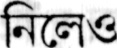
নিলেও
